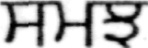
ਸਮਝ
